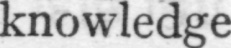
knowledge
